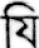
যি
